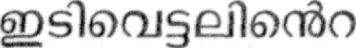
ഇടിവെട്ടലിന്റെ
